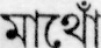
মাথোঁ
